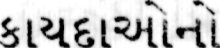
કાયદાઓનો
